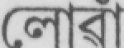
লোৱাঁ
